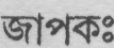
জাপকঃ
